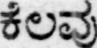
ಕೆಲವು
